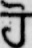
ਹੋ
